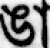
ঙা
